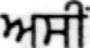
ਅਸੀਂ
